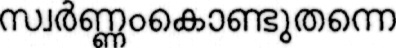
സ്വര്‍ണ്ണംകൊണ്ടുതന്നെ
